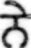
ਨੇ
